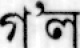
গ'ল
